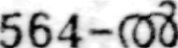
564-ല്‍
